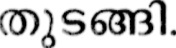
തുടങ്ങി.
